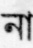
না
